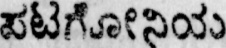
ಪಟಗೋನಿಯ
